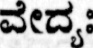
ವೇದ್ಯಃ
